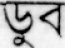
ডুব
